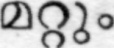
മറ്റും
